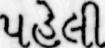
પહેલા
